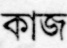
কাজ
